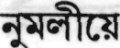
নুমলীয়ে
